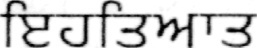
ਇਹਤਿਆਤ
